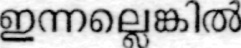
ഇന്നല്ലെങ്കില്‍
